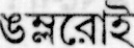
ঙম্লরোই
